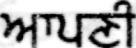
ਆਪਣੀ
